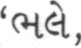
'ભલે,
